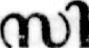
സി
